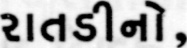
રાતડીનો,
